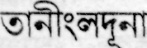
তানীংলদূনা
